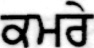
ਕਮਰੇ
